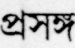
প্রসঙ্গ
